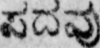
ಪದವು
